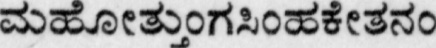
ಮಹೋತ್ತುಂಗಸಿಂಹಕೇತನಂ
